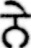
ਨੇ
